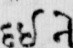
દઈને
